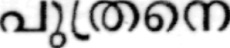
പുത്രനെ
